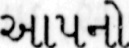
આપનો
